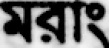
মরাং
